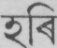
হৰি
